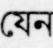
যেন
